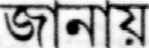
জানায়
